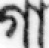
গা
